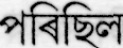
পৰিছিল
